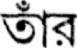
তাঁর
